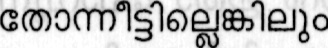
തോന്നീട്ടില്ലെങ്കിലും
